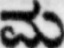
ಮ
